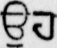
ਉਹ
